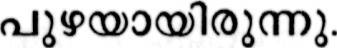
പുഴയായിരുന്നു.
